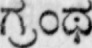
ಗ್ರಂಥ
